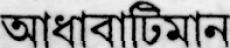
আধাবাটিমান
